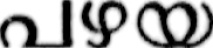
പഴയ
